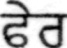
ਫੇਰ
